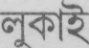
লুকাই
